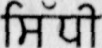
ਸਿੱਧੀ
